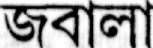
জবালা
